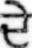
ਦੇ
